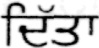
ਦਿੱਤਾ
